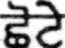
ਛੋਟੇ
